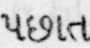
પછાત
